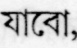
যাবো,
